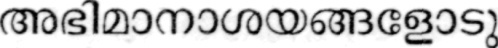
അഭിമാനാശയങ്ങളോടു
